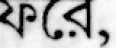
ফরে,
